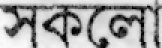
সকলো
